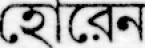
হোরেন
